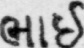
ભાઈ
